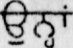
ਉਨ੍ਹਾਂ
